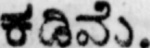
ಕಡಿಮೆ.
